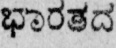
ಭಾರತದ
